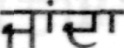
ਜਾਂਦਾ
